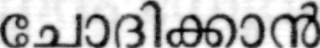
ചോദിക്കാന്‍
